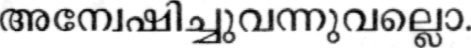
അന്വേഷിച്ചുവന്നുവല്ലൊ.
